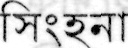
সিংহনা
